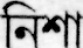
নিশা
